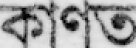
কাণত
